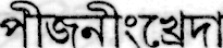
পীজনীংখ্রেদা
